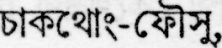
চাকথোং-ফৌসু,
